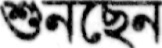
শুনছেন
